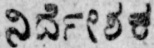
ನಿರ್ದೇಶಕ
